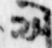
એ
